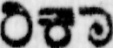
ರಿಕಾ
